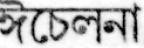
ঈচেলনা
